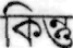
কিন্তু
